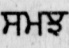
ਸਮਝ
